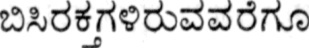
ಬಿಸಿರಕ್ತಗಳಿರುವವರೆಗೂ
